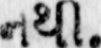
નથી.
